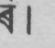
ৰ।
